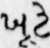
ખૂટે
